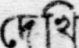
দেখি
